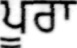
ਪੂਰਾ
